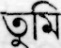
তুমি
